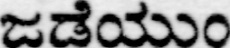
ಜಡೆಯುಂ
